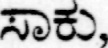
ಸಾಕು,
